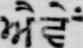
ਐਵੇਂ
